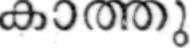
കാത്തു
